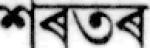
শৰতৰ
